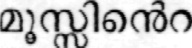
മൂസ്സിന്റെ
